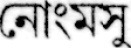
নোংমসু
